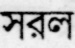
সরল
